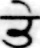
ਤੇ
